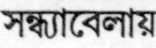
সন্ধ্যাবেলায়
